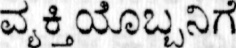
ವ್ಯಕ್ತಿಯೊಬ್ಬನಿಗೆ
